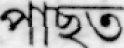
পাছত
